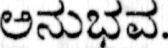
ಅನುಭವ.
